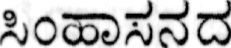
ಸಿಂಹಾಸನದ
